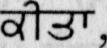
ਕੀਤਾ,
